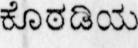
ಕೊಠಡಿಯ
